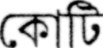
কোটি
